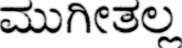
ಮುಗೀತಲ್ಲ
